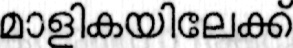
മാളികയിലേക്ക്
